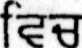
ਵਿਚ
